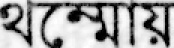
থম্মোয়
